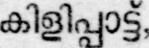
കിളിപ്പാട്ട്,
